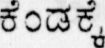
ಕೆಂಡಕ್ಕೆ
